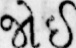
જોઈ
